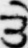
ਤੇ
